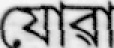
যোৱা
